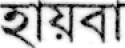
হায়বা
